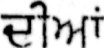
ਦੀਆਂ
